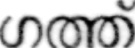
ഗത്ത്
